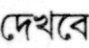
দেখবে
